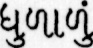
ધુળાળું
